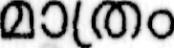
മാത്രം
